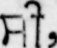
ਸੀ,
